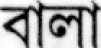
বালা
